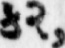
કર,
